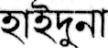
হাইদুনা
